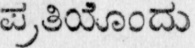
ಪ್ರತಿಯೊಂದು
